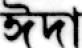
ঈদা
